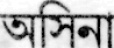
অসিনা
